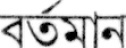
বর্তমান
